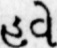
હવે
